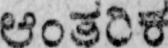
ಆಂತರಿಕ
